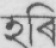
হৰি
